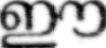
ഈ
